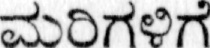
ಮರಿಗಳಿಗೆ
